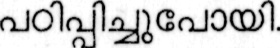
പഠിപ്പിച്ചുപോയി.
